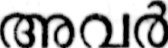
അവര്‍
